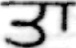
ਤਾਂ
